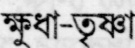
ক্ষুধা-তৃষ্ণা
